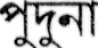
পুদুনা
